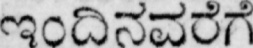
ಇಂದಿನವರೆಗೆ
